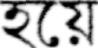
হয়ে
